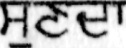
ਸੁਣਦਾ
